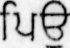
ਪਿਉ
